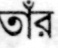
তাঁর
